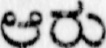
ಆರು
